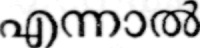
എന്നാല്‍
